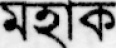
মহাক
